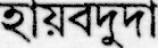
হায়বদুদা
